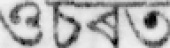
ওচৰত
